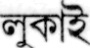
লুকাই
